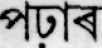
পঢ়াৰ
